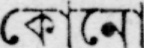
কোনো
